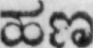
ಹಣ
